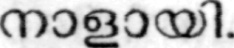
നാളായി.
